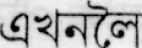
এখনলৈ
